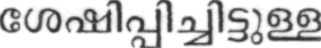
ശേഷിപ്പിച്ചിട്ടുള്ള
